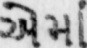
એમાં
